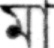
মা
